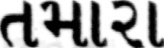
તમારા
